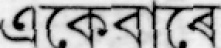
একেবাৰে
